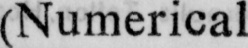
(Numerical
